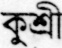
কুশ্রী
